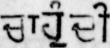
ਚਾਹੁੰਦੀ
